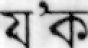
য'ক
